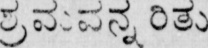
ಶ್ರಮವನ್ನರಿತು
